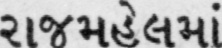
રાજમહેલમાં
